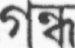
গন্ধ
